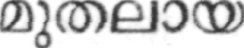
മുതലായ
